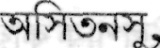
অসিতনসু,
